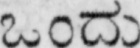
ಒಂದು
